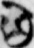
છે
